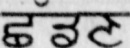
ਛੱਡਣ
